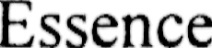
Essence
